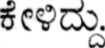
ಕೇಳಿದ್ದು.
